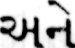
અને
